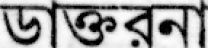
ডাক্তরনা
